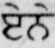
ਏਨੇ
